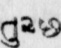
તુચ્છ
